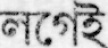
লগেই
